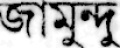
জামুন্দু
